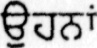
ਉਹਨਾਂ
